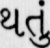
થતું
